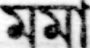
মমা
